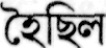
হৈছিল
